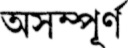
অসম্পূর্ণ
